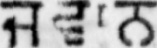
ਜਵਾਨ
